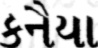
કનૈયા
